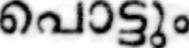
പൊട്ടും
